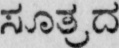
ಸೂತ್ರದ
